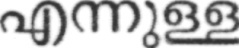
എന്നുള്ള
